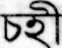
চহী
